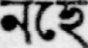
নহে
